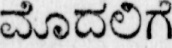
ಮೊದಲಿಗೆ
